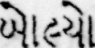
બોલ્યો
